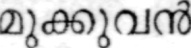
മുക്കുവന്‍
